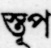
স্তূপ
